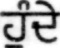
ਹੁੰਦੇ
